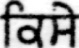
ਕਿਸੇ
